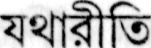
যথারীতি
